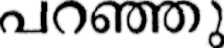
പറഞ്ഞു
